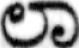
ಲಾ
